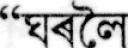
"ঘৰলৈ
